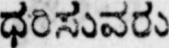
ಧರಿಸುವರು
